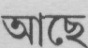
আছে
